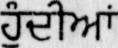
ਹੁੰਦੀਆਂ
